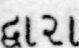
દ્વારા
